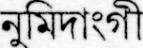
নুমিদাংগী
